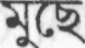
মুছে
